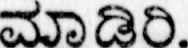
ಮಾಡಿರಿ.
